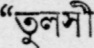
‘‘তুলসী
